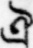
ঐ
